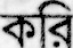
করি
